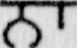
ਨਾ
